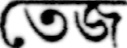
তেজ
